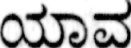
ಯಾವ
